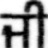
ਜੀ
